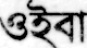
ওইবা
